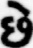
છે
